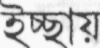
ইচ্ছায়
